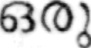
ഒരു
